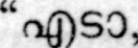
“എടാ,
